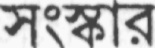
সংস্কার
